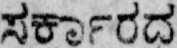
ಸರ್ಕಾರದ
